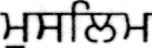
ਮੁਸਲਿਮ
